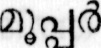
മൂപ്പര്‍
